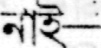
নাই—
